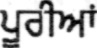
ਪੂਰੀਆਂ
